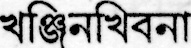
খঞ্জিনখিবনা
